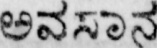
ಅವಸಾನ
